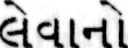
લેવાનો
